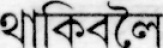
থাকিবলৈ
